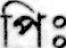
পিঃ
